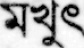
মখুৎ
